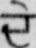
ਦੇ
